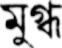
মুগ্ধ
